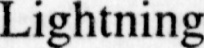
Lightning
